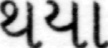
થયા
